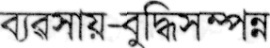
ব্যৱসায়-বুদ্ধিসম্পন্ন
